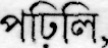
পঢ়িলি,
